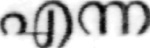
എന്ന
